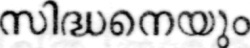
സിദ്ധനെയും
